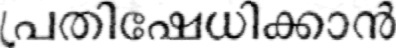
പ്രതിഷേധിക്കാന്‍
